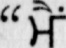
''ਮੈਂ
